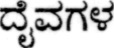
ದೈವಗಳ
